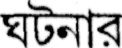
ঘটনার
